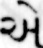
એ
